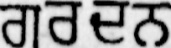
ਗਰਦਨ
